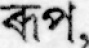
ৰূপ,
